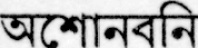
অশোনবনি
